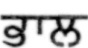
ਭਾਲ
